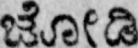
ಜೋಡಿ
